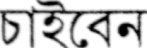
চাইবেন
